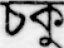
চকু
